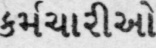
કર્મચારીઓ
